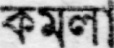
কমলা
